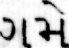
ગમે
